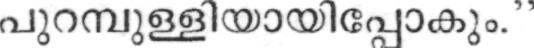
പുറമ്പുള്ളിയായിപ്പോകും."
